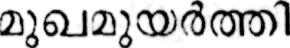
മുഖമുയര്‍ത്തി
